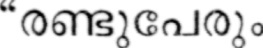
"രണ്ടുപേരും
